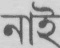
নাই
